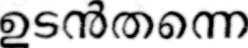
ഉടന്‍തന്നെ
